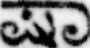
ಷಾ
